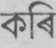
কৰি
